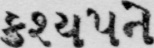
કશ્યપને
